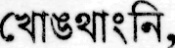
খোঙথাংনি,
